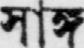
সাঙ্গ
